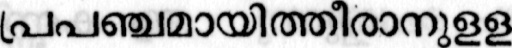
പ്രപഞ്ചമായിത്തീരാനുള്ള
